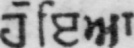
ਹੋਇਆ
